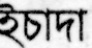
ইচাদা
